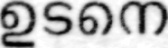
ഉടനെ
